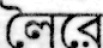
লৈরে
